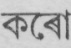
কৰো
